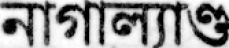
নাগাল্যণ্ড
